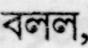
বলল,
